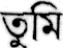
তুমি
